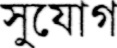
সুযোগ
